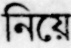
নিয়ে
